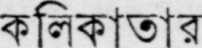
কলিকাতার
